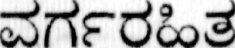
ವರ್ಗರಹಿತ
